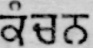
ਕੰਚਨ
